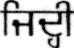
ਜਿਦ੍ਹੀ
